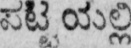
ಪಟ್ಟಿಯಲ್ಲಿ
